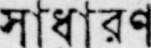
সাধারণ
